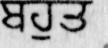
ਬਹੁਤ
